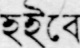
হইবে
